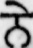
ਨੇ
